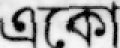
একো
